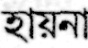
হায়না
